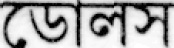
ডোলস
